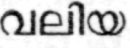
വലിയ
